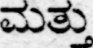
ಮತ್ತು
